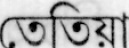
তেতিয়া
